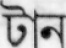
টান
